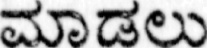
ಮಾಡಲು
